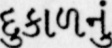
દુકાળનું
